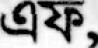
এফ,
